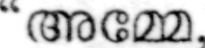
“അമ്മേ,
